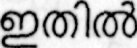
ഇതില്‍
